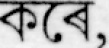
কৰে,
